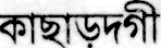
কাছাড়দগী
